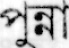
পুন্না
